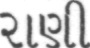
રાણી
